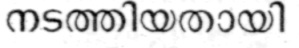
നടത്തിയതായി
